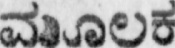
ಮೂಲಕ
